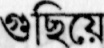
গুছিয়ে
